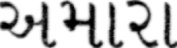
અમારા
